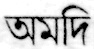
অমদি
